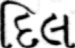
દિલ
